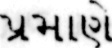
પ્રમાણે
